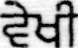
ਵੇਖੀ
